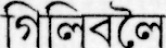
গিলিবলৈ
